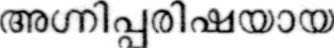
അഗ്നിപ്പരിഷയായ
